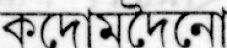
কদোমদৈনো
